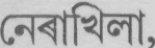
নেৰাখিলা,
